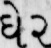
ઘેર
